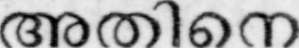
അതിനെ
